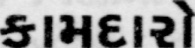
કામદારો
